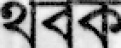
থবক
